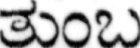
ತುಂಬ
